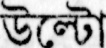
উল্টো
